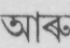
আৰু
